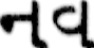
નવ
